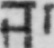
ਜਾ
